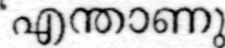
‘എന്താണു
